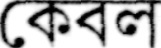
কেবল
